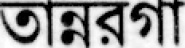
তান্নরগা
